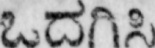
ಒದಗಿಸಿ
